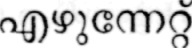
എഴുന്നേറ്റ്
